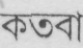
কতবা
